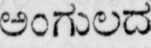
ಅಂಗುಲದ
